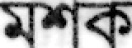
মশক
